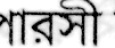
পারসী
